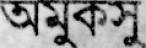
অমুকসু
